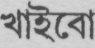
খাইবো
